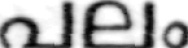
പലം
